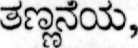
ತಣ್ಣನೆಯ,
